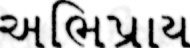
અભિપ્રાય
